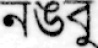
নঙবু
